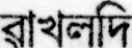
ৱাখলদি
